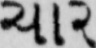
ચાર
